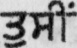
ਤੁਸੀਂ
